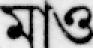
মাও
